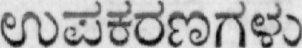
ಉಪಕರಣಗಳು
